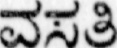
ವಸತಿ
